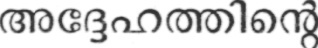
അദ്ദേഹത്തിന്റെ
